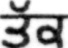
ਤੱਕ
